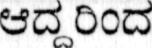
ಆದ್ದರಿಂದ
